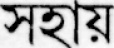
সহায়
